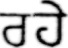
ਰਹੇ
